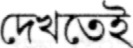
দেখতেই
